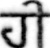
ਹੀ
